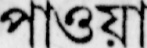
পাওয়া
